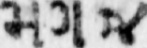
મગજ
